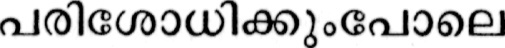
പരിശോധിക്കുംപോലെ
